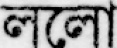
ললো
